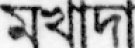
মখাদা
